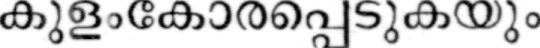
കുളംകോരപ്പെടുകയും
